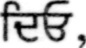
ਦਿਓ,
